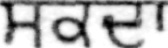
ਸਕਦਾ
